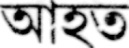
আহত
